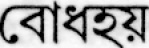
বোধহয়
